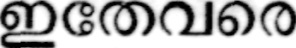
ഇതേവരെ
